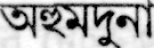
অহুমদুনা
